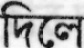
দিলে
